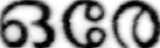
ഒരേ
